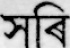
সৰি
